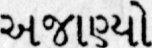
અજાણ્યો
